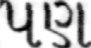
પણ
